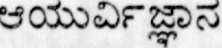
ಆಯುರ್ವಿಜ್ಞಾನ
